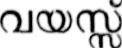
വയസ്സ്
